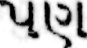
પણ
